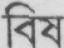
বিষ
